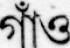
গাঁও
